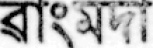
ৱাংমদা
